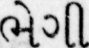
ભેગી
